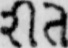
રીતે
